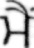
ਮੈਂ
